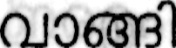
വാങ്ങി
